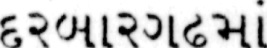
દરબારગઢમાં
